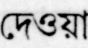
দেওয়া
